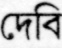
দেবি
